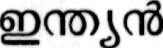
ഇന്ത്യന്‍
